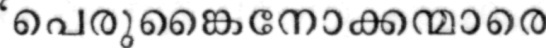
'പെരുങ്കൈനോക്കന്മാരെ
